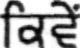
ਕਿਵੇਂ
